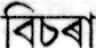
বিচৰা
